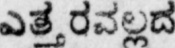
ಎತ್ತರವಲ್ಲದ
